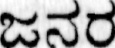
ಜನರ
